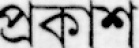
প্রকাশ
